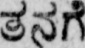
ತನಗೆ
